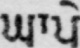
ਘਾਪੇ
